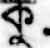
কু.
